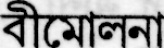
বীমোলনা
